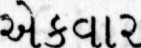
એકવાર
